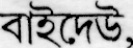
বাইদেউ,
